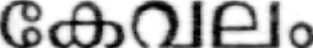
കേവലം
